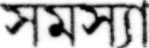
সমস্যা
